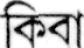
কিবা
